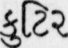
કુટિર
